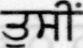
ਤੁਸੀਂ
